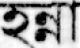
হন্না
